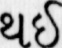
થઈ
